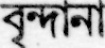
বৃন্দানা
